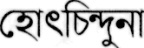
হোৎচিন্দুনা
